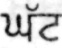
ਘੱਟ
